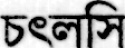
চৎলসি
